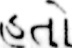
હતો
